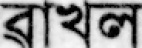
ৱাখল
